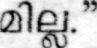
മില്ല.”
